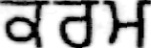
ਕਰਮ
